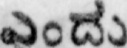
ಎಂದು
